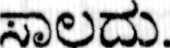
ಸಾಲದು.
